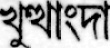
খুত্থাংদা
